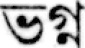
ভগ্ন
